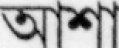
আশা
